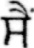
ਸੈਂ
